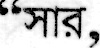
“সার,
